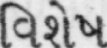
વિશેષ
